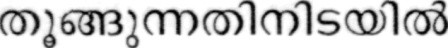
തൂങ്ങുന്നതിനിടയില്‍
